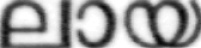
ലായ
